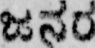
ಜನರ
